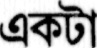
একটা
